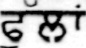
ਫੁੱਲਾਂ
